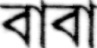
বাবা
